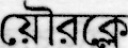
য়ৌরক্লে
